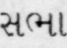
સભા
